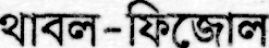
থাবল-ফিজোল
